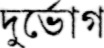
দুর্ভোগ
